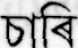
চাৰি
